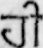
ਹੀ
